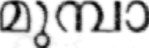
മുമ്പാ
